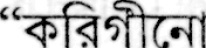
“করিগীনো
